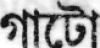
গাটো
